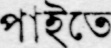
পাইতে
